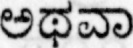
ಅಥವಾ
